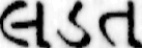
લડત
